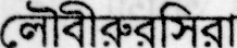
লৌবীরুরসিরা
